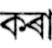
কৰা
